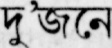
দু'জনে
